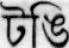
টঙি
